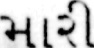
મારી
